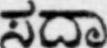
ಸದಾ
